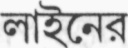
লাইনের
